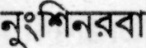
নুংশিনরবা
